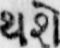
થશે
